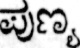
ಪುಣ್ಯ
